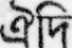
ঐদি
